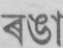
ৰঙা
